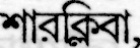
শারক্লিবা,
